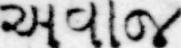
અવાજ
